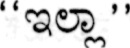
"ಇಲ್ಲಾ"
